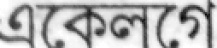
একেলগে
